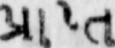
પ્રાપ્ત
